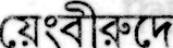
য়েংবীরুদে
